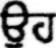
ਉਹ
